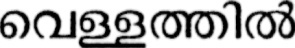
വെള്ളത്തില്‍
